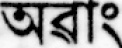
অৱাং
